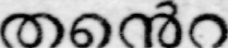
തന്റെ
